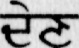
ਦੇਣ
